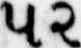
પર
